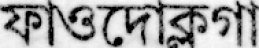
ফাওদোক্লগা
